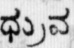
ಧ್ರುವ
